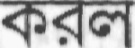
করল
